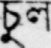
চুল
